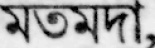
মতমদা,
